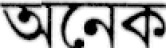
অনেক
